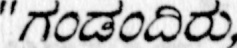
“ಗಂಡಂದಿರು,
